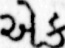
એક
